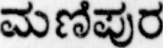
ಮಣಿಪುರ
